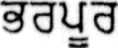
ਭਰਪੂਰ
